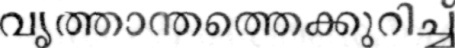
വൃത്താന്തത്തെക്കുറിച്ച്
